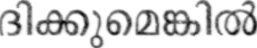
ദിക്കുമെങ്കില്‍
